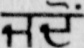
ਜਦੋਂ
